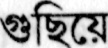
গুছিয়ে
